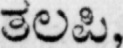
ತಲಪಿ,
